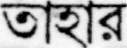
তাহার
